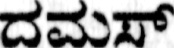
ದಮಸ್
